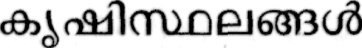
കൃഷിസ്ഥലങ്ങള്‍
